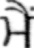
ਮੈਂ
